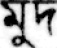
মুদ
